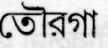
তৌরগা
